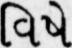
વિષે
